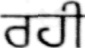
ਰਹੀ
